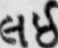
લઈ
